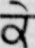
ਕੇ
